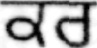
ਕਰ
